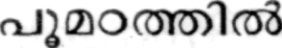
പൂമഠത്തില്‍
